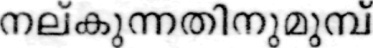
നല്കുന്നതിനുമുമ്പ്
